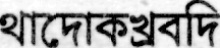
থাদোকখ্রবদি
